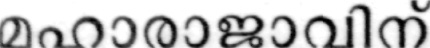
മഹാരാജാവിന്
